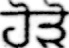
ਹੋੜੋ
